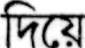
দিয়ে
